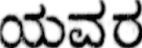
ಯವರ
